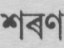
শৰণ
